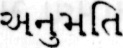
અનુમતિ
